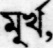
মূর্খ,
